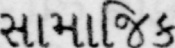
સામાજિક
